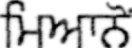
ਮਿਆਨੋਂ
